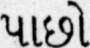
પાછો
